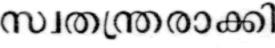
സ്വതന്ത്രരാക്കി
